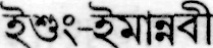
ইশুং-ইমান্নবী
